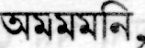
অমমমনি,
